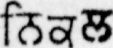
ਨਿਕਲ
